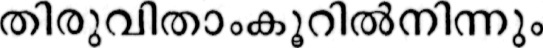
തിരുവിതാംകൂറില്‍നിന്നും
